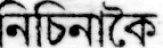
নিচিনাকৈ
